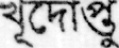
খূদোপ্তু
